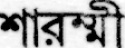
শারম্মী
